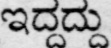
ಇದ್ದದ್ದು
